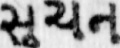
સુચન
